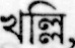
খল্লি,
